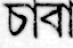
চাবা
